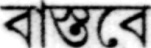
বাস্তবে
